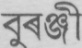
বুৰঞ্জী
